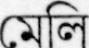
মেলি
